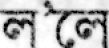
ল'লে
